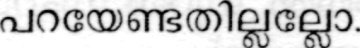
പറയേണ്ടതില്ലല്ലോ.
